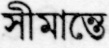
সীমান্তে
